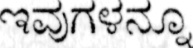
ಇವುಗಳನ್ನೂ
